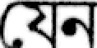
যেন
